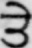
ਤੇ
